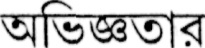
অভিজ্ঞতার
